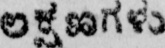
ಲಕ್ಷಣಗಳು
